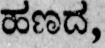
ಹಣದ,
